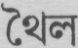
থৈল
